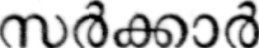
സര്‍ക്കാര്‍
